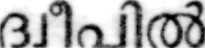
ദ്വീപില്‍
